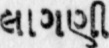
લાગણી
